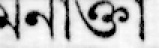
মনাক্তা
